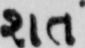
શત
